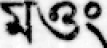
মওং
